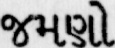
જમણો
